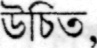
উচিত,
